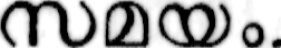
സമയം.
